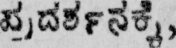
ಪ್ರದರ್ಶನಕ್ಕೆ,
